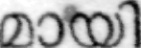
മായി
